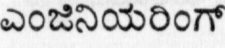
ಎಂಜಿನಿಯರಿಂಗ್
